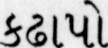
કઢાપો
